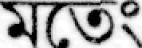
মতেং
